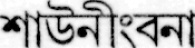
শাউনীংবনা
